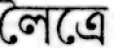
লৈত্রে
